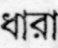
ধারা
